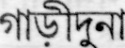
গাড়ীদুনা
